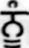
ਨੂੰ
